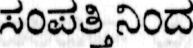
ಸಂಪತ್ತಿನಿಂದ
